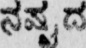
ನಷ್ಟದ
